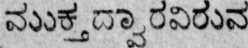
ಮುಕ್ತದ್ವಾರವಿರುವ
